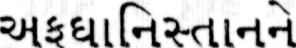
અફઘાનિસ્તાનને
